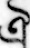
ঐ
